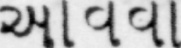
આવવા
